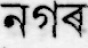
নগৰ
